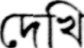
দেখি
